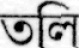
তলি
